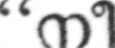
“നീ
